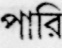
পারি
